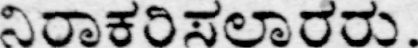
ನಿರಾಕರಿಸಲಾರರು.
